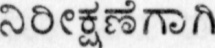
ನಿರೀಕ್ಷಣೆಗಾಗಿ
